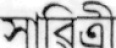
সাৱিত্রী
